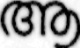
ആ
